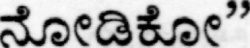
ನೋಡಿಕೋ"
